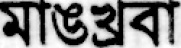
মাঙখ্রবা
